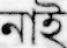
নাই
